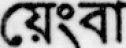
য়েংবা
